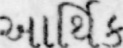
આર્થિક
